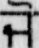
ਜੋ
